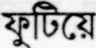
ফুটিয়ে
